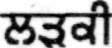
ਲੜਕੀ
